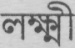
লক্ষ্মী
